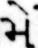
મેં
